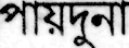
পায়দুনা
